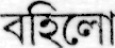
বহিলো
